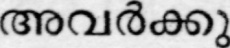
അവര്‍ക്കു
